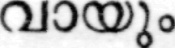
വായും
